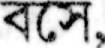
বসে,
